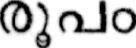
രൂപം
